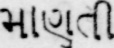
માણતી
